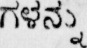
ಗಳನ್ನು
